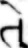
તે
